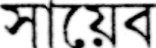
সায়েব
